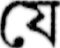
যে
